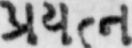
પ્રયત્ન
